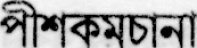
পীশকমচানা
